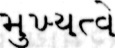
મુખ્યત્વે
